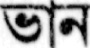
ভান
